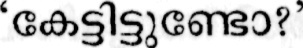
'കേട്ടിട്ടുണ്ടോ?’
